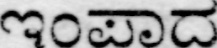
ಇಂಪಾದ
